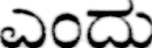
ಎಂದು
